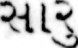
સારુ
